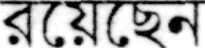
রয়েছেন
